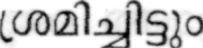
ശ്രമിച്ചിട്ടും
